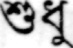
শুধু
